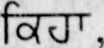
ਕਿਹਾ,
